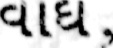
વાઘ,
